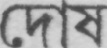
দোষ
